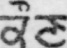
ਕੌਣ
